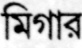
মিগার
